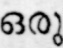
ഒരു
